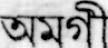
অমগী
